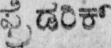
ಫ್ರೆಡರಿಕ್
